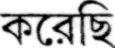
করেছি
